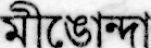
মীঙোন্দা
